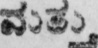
ಮತ್ತು
